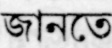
জানতে
